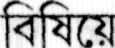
বিষিয়ে
